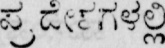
ಪ್ರದೇಶಗಳಲ್ಲಿ
